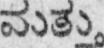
ಮತ್ತು
